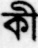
কী
